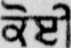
ਕੋਈ
